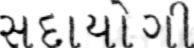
સદાયોગી
